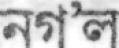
নগ'ল
